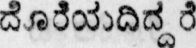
ದೊರೆಯದಿದ್ದರೆ
